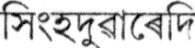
সিংহদুৱাৰেদি
